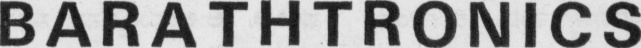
BARATHTRONICS
